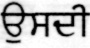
ਉਸਦੀ
